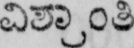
ವಿಶ್ರಾಂತಿ
